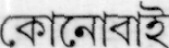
কোনোবাই
